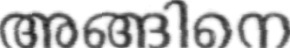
അങ്ങിനെ
